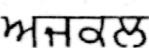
ਅਜਕਲ
